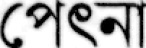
পেৎনা
